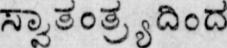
ಸ್ವಾತಂತ್ರ್ಯದಿಂದ
